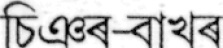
চিঞৰ-বাখৰ
